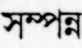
সম্পন্ন
